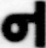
ન
